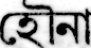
হৌনা
